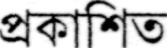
প্রকাশিত
